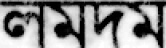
লমদম
